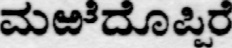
ಮಱೆದೊಪ್ಪಿರೆ
